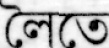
লৈতে
